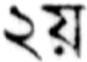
২য়
